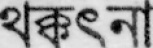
থক্কৎনা
